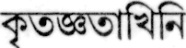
কৃতজ্ঞতাখিনি
